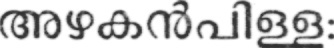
അഴകന്‍പിള്ള:
